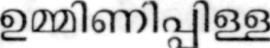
ഉമ്മിണിപ്പിള്ള
